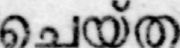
ചെയ്ത
